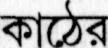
কাঠের
